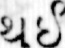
થઈ
